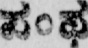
ಪಂಥ
